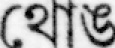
থোঙ
